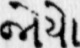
જોયો
